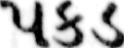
પકડ
